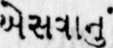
બેસવાનું
